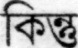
কিন্তু
